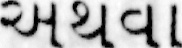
અથવા
